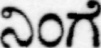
ನಿಂಗೆ
